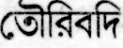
তৌরিবদি
